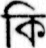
কি
